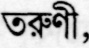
তরুণী,
